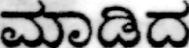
ಮಾಡಿದ
